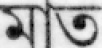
মাত
